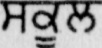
ਸਕੂਲ
